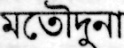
মতৌদুনা
